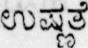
ಉಷ್ಣತೆ
